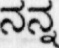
ನನ್ನ
